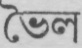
ভৈল
